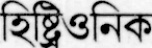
হিষ্ট্রিওনিক
